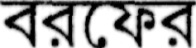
বরফের
